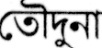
তৌদুনা
